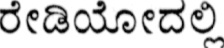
ರೇಡಿಯೋದಲ್ಲಿ
